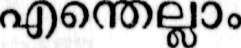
എന്തെല്ലാം
